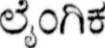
ಲೈಂಗಿಕ
